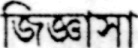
জিজ্ঞাসা
